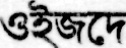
ওইজদে
